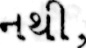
નથી,
